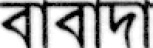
বাবাদা
